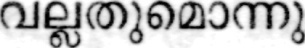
വല്ലതുമൊന്നു
